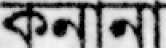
কনানা
